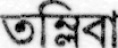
তম্লিবা
